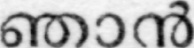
ഞാന്‍
